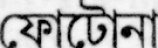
ফোটোনা
